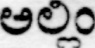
ಅಲ್ಲಿಂ
